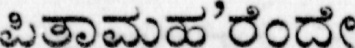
ಪಿತಾಮಹ’ರೆಂದೇ
